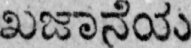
ಖಜಾನೆಯ
